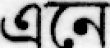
এনে
